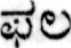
ಫಲ
